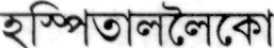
হস্পিতাললৈকো
